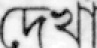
দেখা
